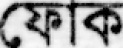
ফোক
